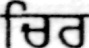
ਚਿਰ
